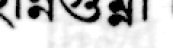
হনতন্না
